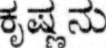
ಕೃಷ್ಣನು
